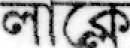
লাক্লে
